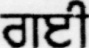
ਗਈ
